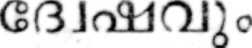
ദ്വേഷവും
